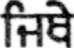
ਜਿਥੇ
